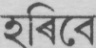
হৰিবে
